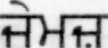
ਜੇਮਜ਼
